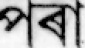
পৰা
